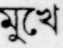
মুখে
